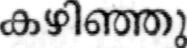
കഴിഞ്ഞു
